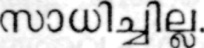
സാധിച്ചില്ല.
